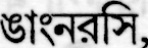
ঙাংনরসি,
